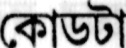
কোডটা
